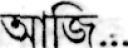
আজি...
